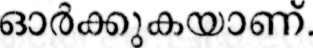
ഓര്‍ക്കുകയാണ്.
